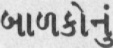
બાળકોનું
